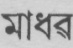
মাধৱ
